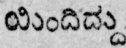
ಯಿಂದಿದ್ದು
